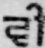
ਵੀ
